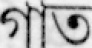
গাত
